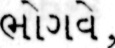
ભોગવે,
